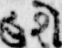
હશે
